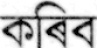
কৰিব
